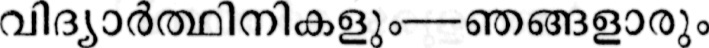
വിദ്യാര്‍ത്ഥിനികളും-ഞങ്ങളാരും
